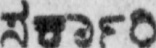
ಸರ್ಕಾರಿ
